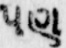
પણ
